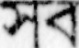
সব
